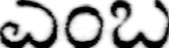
ಎಂಬ
